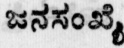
ಜನಸಂಖ್ಯೆ
